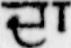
ਦਾ
